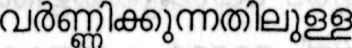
വര്‍ണ്ണിക്കുന്നതിലുള്ള
